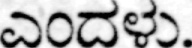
ಎಂದಳು.
